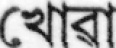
খোৱা
